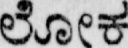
ಲೋಕ
